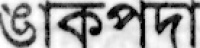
ঙাকপদা
